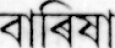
বাৰিষা
